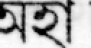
অহা
